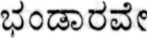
ಭಂಡಾರವೇ
